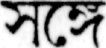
সঙ্গে
